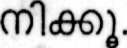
നിക്കൂ.
